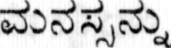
ಮನಸ್ಸನ್ನು
